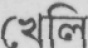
খেলি
